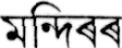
মন্দিৰৰ
